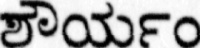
ಶೌರ್ಯ೦
